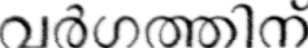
വര്‍ഗത്തിന്
